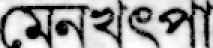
মেনখৎপা
